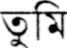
তুমি
